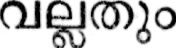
വല്ലതും
